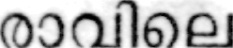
രാവിലെ
